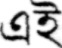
এই
